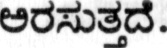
ಅರಸುತ್ತದೆ.
